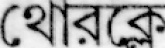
থোরক্লে
